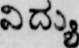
ವಿದ್ಯು
